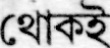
থোকই
